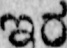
ಇರ
